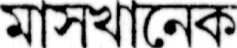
মাসখানেক
